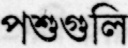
পশুগুলি
